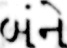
બંને
